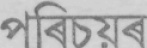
পৰিচয়ৰ
